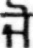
ਜੋ
